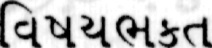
વિષયભક્ત
